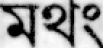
মথং
